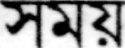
সময়
